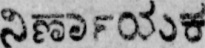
ನಿರ್ಣಾಯಕ
